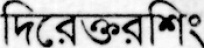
দিরেক্তরশিং
